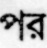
পর
